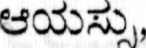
ಆಯಸ್ಸು,
